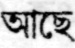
আছে
